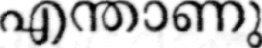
എന്താണു
